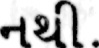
નથી.
